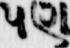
પણ
